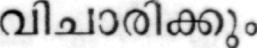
വിചാരിക്കും
